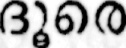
ദൂരെ
